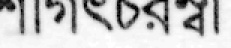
শাগৎচরম্বা
